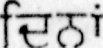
ਦਿਨਾਂ
